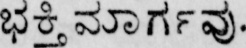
ಭಕ್ತಿಮಾರ್ಗವು.
